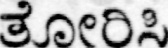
ತೋರಿಸಿ
